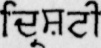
ਦ੍ਰਿਸ਼ਟੀ
